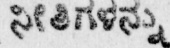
ನೀತಿಗಳನ್ನು
